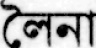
লৈনা
